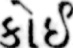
કોઈ
